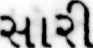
સારી
